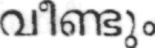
വീണ്ടും
